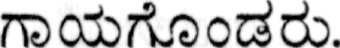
ಗಾಯಗೊಂಡರು.
